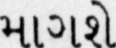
માગશે
